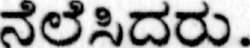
ನೆಲೆಸಿದರು.
